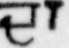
ਦਾ
